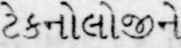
ટેકનોલોજીને
